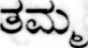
ತಮ್ಮ
